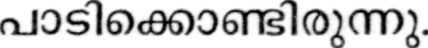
പാടിക്കൊണ്ടിരുന്നു.
